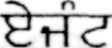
ਏਜੰਟ
